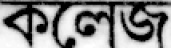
কলেজ
